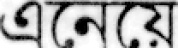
এনেয়ে
